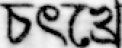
চৎখ্রে
